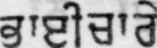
ਭਾਈਚਾਰੇ
